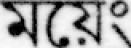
ময়েং
